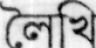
লৈখি
